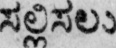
ಸಲ್ಲಿಸಲು
